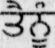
ਤੈਨੂੰ
